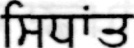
ਸਿਧਾਂਤ
